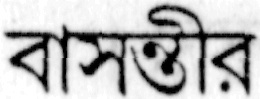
বাসন্তীর
